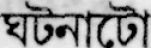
ঘটনাটো
